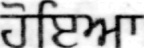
ਹੋਇਆ
